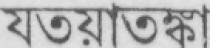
যতয়াতঙ্কা
